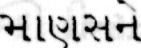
માણસને
